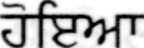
ਹੋਇਆ
